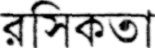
রসিকতা
